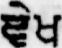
ਵੇਖ
